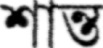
শান্ত
